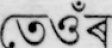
তেওঁৰ
